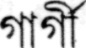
গার্গী
